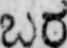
ಬರ
